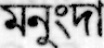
মনুংদা
